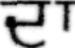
ਦਾ
